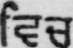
ਵਿਚ
